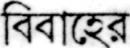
বিবাহের
